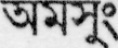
অমসুং
